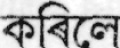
কৰিলে
